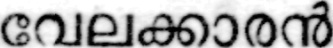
വേലക്കാരന്‍
